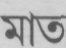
মাত
